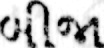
બીજા
